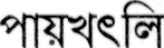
পায়খৎলি
